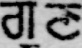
ਗੁਣ
